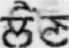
ਲੈਣ
